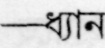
–ধ্যান
